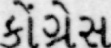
કોંગ્રેસ
